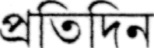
প্রতিদিন
